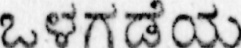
ಒಳಗಡೆಯ
